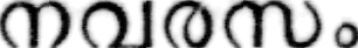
നവരസം
